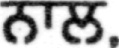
ਨਾਲ,
